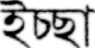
ইচ্ছা
